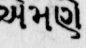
એમણે
